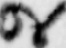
જ
